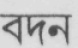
বদন
